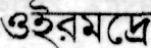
ওইরমদ্রে
